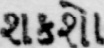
શકશો
